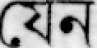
যেন
